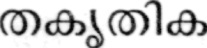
തകൃതിക
